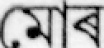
মোৰ
